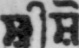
ਸ਼ੀਸ਼ੋ
